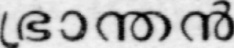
ഭ്രാന്തന്‍
